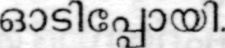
ഓടിപ്പോയി.
